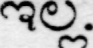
ಇಲ್ಲ.
